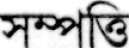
সম্পত্তি
